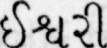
ઈશ્વરી
